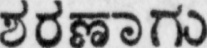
ಶರಣಾಗು
